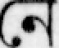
নে
